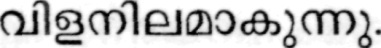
വിളനിലമാകുന്നു.
